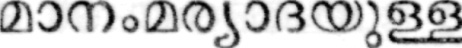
മാനംമര്യാദയുള്ള
